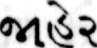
જાહેર
